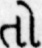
તો
